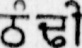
ਠੰਢੀ
